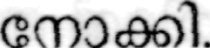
നോക്കി.
